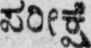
ಪರೀಕ್ಷೆ
